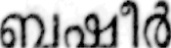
ബഷീര്‍
